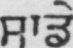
ਸਾਡੇ
